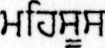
ਮਹਿਸੂਸ
